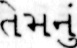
તેમનું
